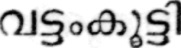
വട്ടംകൂട്ടി
